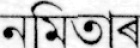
নমিতাৰ
